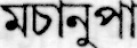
মচানুপা
